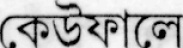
কেউফালে
